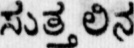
ಸುತ್ತಲಿನ
